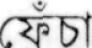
ফেঁচা
